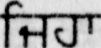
ਜਿਹਾ
